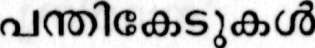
പന്തികേടുകള്‍
